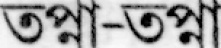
তপ্না-তপ্না
